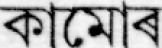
কামোৰ
